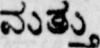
ಮತ್ತು
